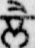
ਲੈ
